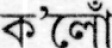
ক'লোঁ
